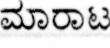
ಮಾರಾಟ
